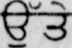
ਉੱਤੇ
